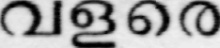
വളരെ
